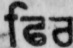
ਫਿਰ
